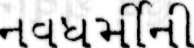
નવધર્મીની
